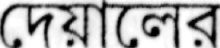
দেয়ালের
